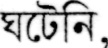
ঘটেনি,
